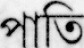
পাতি
